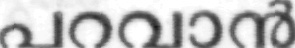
പറവാന്‍
